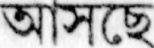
আসছে
